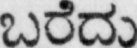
ಬರೆದು
